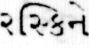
રસ્કિને
